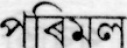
পৰিমল
